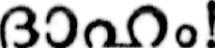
ദാഹം!
